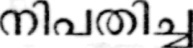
നിപതിച്ച
